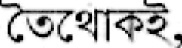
তৈথোকই,
